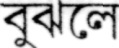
বুঝলে
